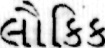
લૌકિક
